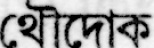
থৌদোক
